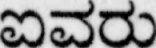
ಐವರು
